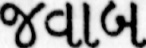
જવાબ
